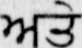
ਅਤੇ
